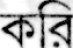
করি
